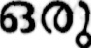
ഒരു
